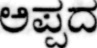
ಅಪ್ಪದ
